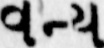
વન્ય
